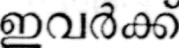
ഇവര്‍ക്ക്
